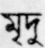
মৃদু
